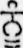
ਨੂੰ
